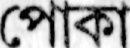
পোকা
